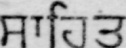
ਸਾਹਿਤ
